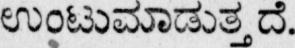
ಉಂಟುಮಾಡುತ್ತದೆ.
